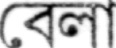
বেলা
